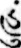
હું
